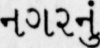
નગરનું
